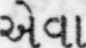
એવા
